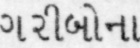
ગરીબોના
